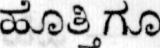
ಹೊತ್ತಿಗೂ
